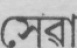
সেৱা
